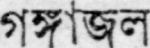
গঙ্গাজল
